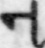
ન
